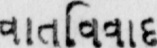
વાતવિવાદ
